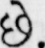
છે.
